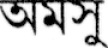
অমসু
